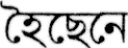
হৈছেনে
